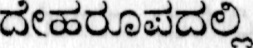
ದೇಹರೂಪದಲ್ಲಿ
